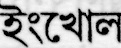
ইংখোল
